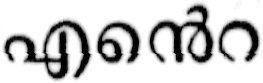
എന്റെ
